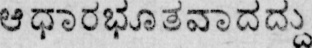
ಆಧಾರಭೂತವಾದದ್ದು
